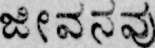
ಜೀವನವು
